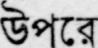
উপরে
